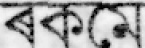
ৰকমে
